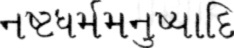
નષ્ટધર્મમનુષ્યાદિ
